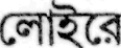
লোইরে
